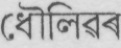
ধৌলিৱৰ
